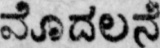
ಮೊದಲನೆ
